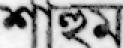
শাহুম
